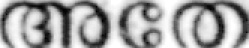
അതേ
